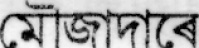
মৌজাদাৰে
